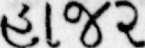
હાજર
